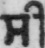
ਸੀ
